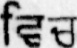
ਵਿਚ
